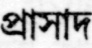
প্রাসাদ
